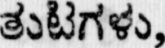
ತುಟಿಗಳು,
